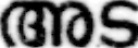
അട
